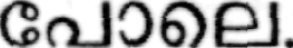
പോലെ.
